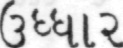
ઉધ્ધાર
